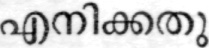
എനിക്കതു
